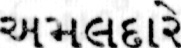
અમલદારે
